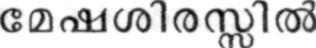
മേഷശിരസ്സില്‍
